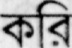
করি
